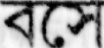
বসে
